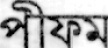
পীফম
